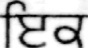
ਇਕ
